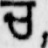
ਚ,
